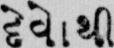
દેવોથી
